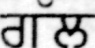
ਗੱਲ
